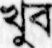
খুব
